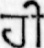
ਹੀ
